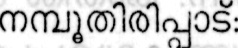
നമ്പൂതിരിപ്പാട്:
